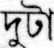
দুটা
